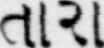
તારા
